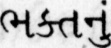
ભક્તનું
